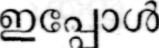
ഇപ്പോള്‍
